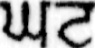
ਘਟ
